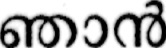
ഞാന്‍
